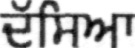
ਦੱਸਿਆ
